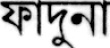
ফাদুনা
